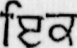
ਇਕ
